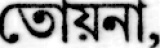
তোয়না,
